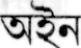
অইন
